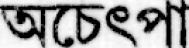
অচেৎপা
